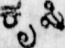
ಕೃಷಿ
